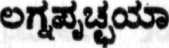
ಲಗ್ನಪೃಚ್ಛಯಾ
